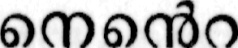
നെന്റെ
